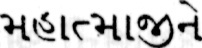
મહાત્માજીને
